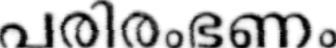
പരിരംഭണം
